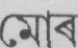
মোৰ
